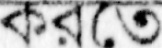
করতে
